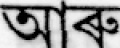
আৰু
